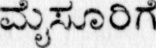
ಮೈಸೂರಿಗೆ
